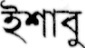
ইশাবু
